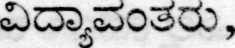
ವಿದ್ಯಾವಂತರು,
